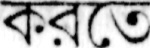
করতে
